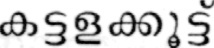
കട്ടളക്കൂട്ട്
